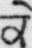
ਕੇ
